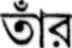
তাঁর
